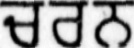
ਚਰਨ
